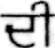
ਦੀ
